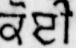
ਕੋਈ
